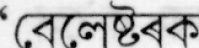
'বেলেষ্টৰক
